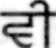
ਵੀ
